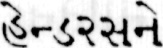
હેન્ડરસને
